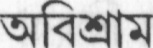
অবিশ্রাম
